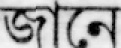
জানে
